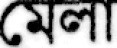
মেলা
